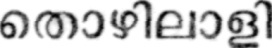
തൊഴിലാളി
